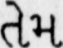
તેમ
